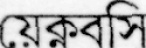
য়েক্নবসি
